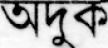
অদুক
